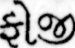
ફોજી
